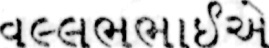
વલ્લભભાઈએ
